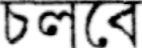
চলবে
